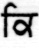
ਕਿ
